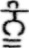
ਨੂੰ
